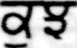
ਕੁਝ
